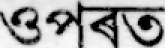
ওপৰত
